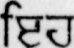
ਇਹ
